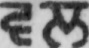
ਵਲ
